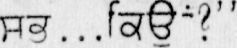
ਸਭ....ਕਿਉਂ?''
